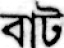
বাট
